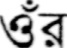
ওঁর
